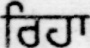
ਰਿਹਾ
